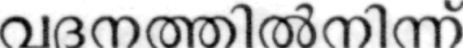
വദനത്തില്‍നിന്ന്
